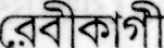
রেবীকাগী
